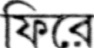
ফিরে
